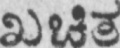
ಖಚಿತ
